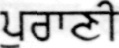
ਪੁਰਾਣੀ
